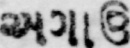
અગાઉ
